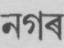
নগৰ
